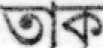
তাক
